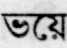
ভয়ে
